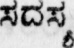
ಸದಸ್ಯ
